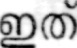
ഇത്
